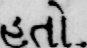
હતો.
